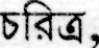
চরিত্র,
